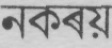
নকৰয়
